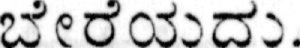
ಬೇರೆಯದು.
